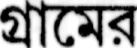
গ্রামের
